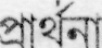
প্রার্থনা
